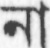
না
